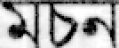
মচন
